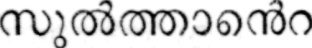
സുല്‍ത്താന്റെ
